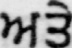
ਅਤੇ
